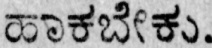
ಹಾಕಬೇಕು.
